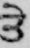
ਤੇ
